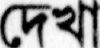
দেখা
